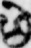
છે
